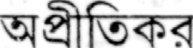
অপ্রীতিকর
